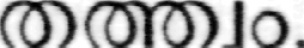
തത്ത്വം.
